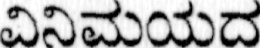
ವಿನಿಮಯದ
